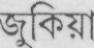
জুকিয়া
